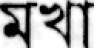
মখা
